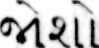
જોશો
